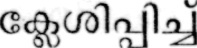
ക്ലേശിപ്പിച്ച്
